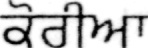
ਕੋਰੀਆ
